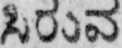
ಸಿರುವ
